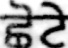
ਛੋਟੇ
